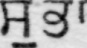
ਸੁਭਾ
